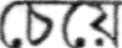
চেয়ে
